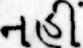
નહીં
